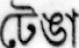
টেঙা
